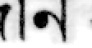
দান
